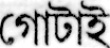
গোটাই
